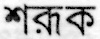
শরূক
